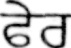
ਫੇਰ
